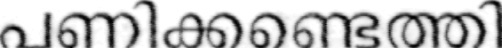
പണിക്കണ്ടെത്തി
